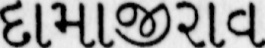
દામાજીરાવ
